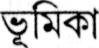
ভূমিকা
